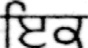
ਇਕ
